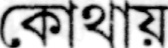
কোথায়
